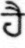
ਹੈ
